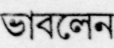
ভাবলেন
